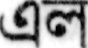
এল
